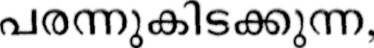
പരന്നുകിടക്കുന്ന,
